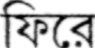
ফিরে
